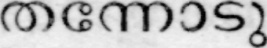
തന്നോടു
